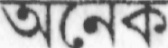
অনেক
